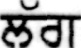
ਲੱਗ
